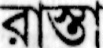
রাস্তা
